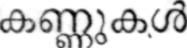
കണ്ണുകള്‍
